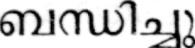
ബന്ധിച്ചു
